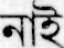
নাই
